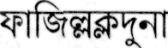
ফাজিল্লক্লদুনা
